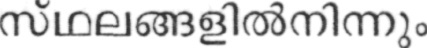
സ്ഥലങ്ങളില്‍നിന്നും
